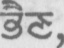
ਭੈਣ,
